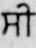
ਸੀ
